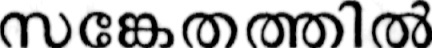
സങ്കേതത്തില്‍
